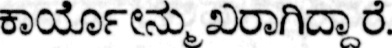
ಕಾರ್ಯೋನ್ಮುಖರಾಗಿದ್ದಾರೆ.
